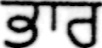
ਭਾਰ
